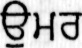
ਉਮਰ
